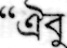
“ঐবু
